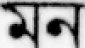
মন
